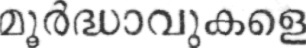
മൂര്‍ദ്ധാവുകളെ
